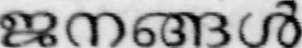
ജനങ്ങള്‍
